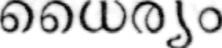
ധൈര്യം
